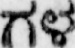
ಗಳ
